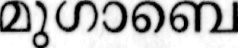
മുഗാബെ
